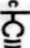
ਨੂੰ
